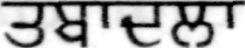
ਤਬਾਦਲਾ
